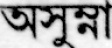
অসুম্না
